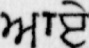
ਆਏ
